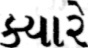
ક્યારે
